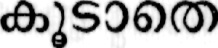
കൂടാതെ
